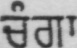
ਚੰਗਾ
